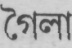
গৈলা
